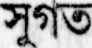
সুগত
